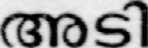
അടി
